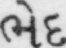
ભેદ
